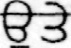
ਉਤੇ
